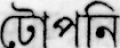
টোপনি
